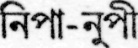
নিপা-নুপী
